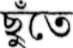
ছুঁতে
